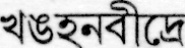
খঙহনবীদ্রে
